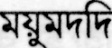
ময়ুমদদি
